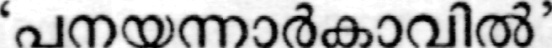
‘പനയന്നാര്‍കാവില്‍’
